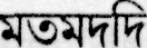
মতমদদি
